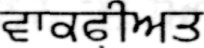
ਵਾਕਫ਼ੀਅਤ
